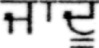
ਜਾਦੂ
